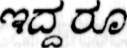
ಇದ್ದರೂ
